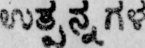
ಉತ್ಪನ್ನಗಳ
